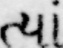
ત્યાં
